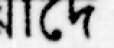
য়াদে
